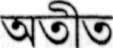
অতীত
